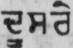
ਦੂਸਰੇ
